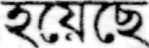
হয়েছে
